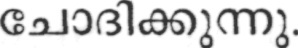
ചോദിക്കുന്നു.
